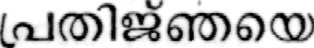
പ്രതിജ്ഞയെ
